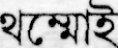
থম্মোই
